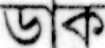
ডাক
